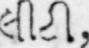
લીટી,
